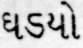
ઘડ્યો
